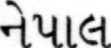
નેપાલ
